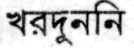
খরদুননি
